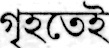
গৃহতেই
